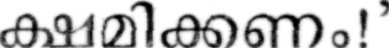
ക്ഷമിക്കണം!’
